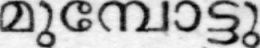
മുമ്പോട്ടു
